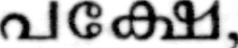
പക്ഷേ,
